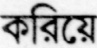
করিয়ে
